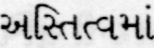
અસ્તિત્વમાં
